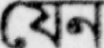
যেন
